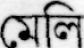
মেলি
